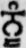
ਨੂੰ
